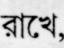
রাখে,
